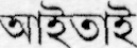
আইতাই
